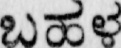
ಬಹಳ
